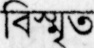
বিস্মৃত
